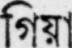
গিয়া
